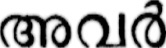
അവര്‍
